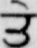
ਤੇ
